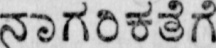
ನಾಗರಿಕತೆಗೆ
